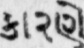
કારણે
